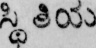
ಸ್ಥಿತಿಯ
